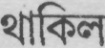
থাকিল
